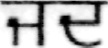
ਜਦ
